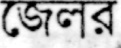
জেলর
